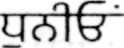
ਧੁਨੀਓਂ
